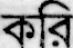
করি
